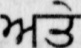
ਅਤੇ
